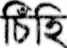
চিঁহি
